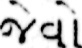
જેવો
